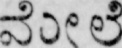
ಮೇಲೆ
